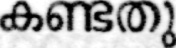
കണ്ടതു
